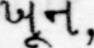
ખૂન,
